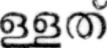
ള്ളത്
